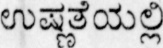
ಉಷ್ಣತೆಯಲ್ಲಿ
